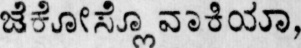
ಜೆಕೋಸ್ಲೊವಾಕಿಯಾ,
